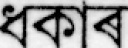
ধকাৰ
